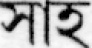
সাহ
